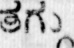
ತಗ್ಗು
